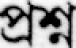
প্রশ্ন
